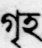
গৃহ
